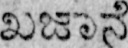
ಖಜಾನೆ
